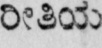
ರೀತಿಯ
